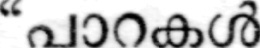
“പാറകള്‍
